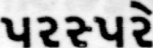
પરસ્પરે
